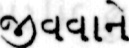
જીવવાને
